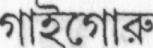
গাইগোরু
